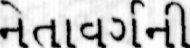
નેતાવર્ગની
